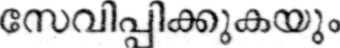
സേവിപ്പിക്കുകയും
